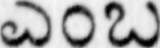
ಎಂಬ
